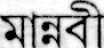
মান্নবী
